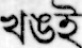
খঙই
